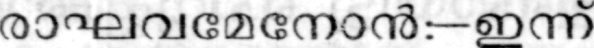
രാഘവമേനോന്‍:-ഇന്ന്
